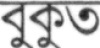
বুকুত
